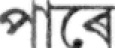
পাৰে
